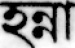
হন্না
